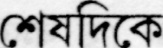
শেষদিকে
